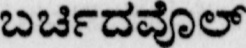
ಬರ್ಚಿದವೊಲ್
